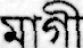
মাগী
